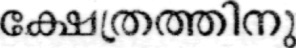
ക്ഷേത്രത്തിനു
